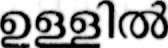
ഉള്ളില്‍
